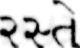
રસ્તે
